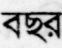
বছর
